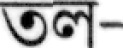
তল-
